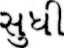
સુધી
